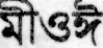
মীওঈ
